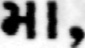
મા,
